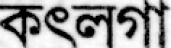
কৎলগা
